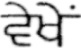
ਵੇਖੇਂ
